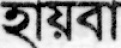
হায়বা
